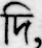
দি,
